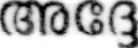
അദ്ദേ
